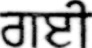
ਗਈ
